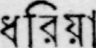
ধরিয়া
